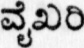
ವೈಖರಿ
